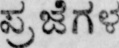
ಪ್ರಜೆಗಳ
